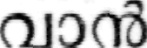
വാന്‍
